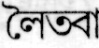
লৈতবা
